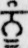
ਨੂੰ
